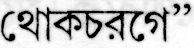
থোকচরগে”
